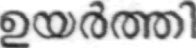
ഉയര്‍ത്തി
